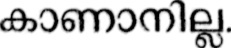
കാണാനില്ല.
